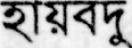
হায়বদু
